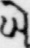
બે
